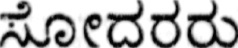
ಸೋದರರು
